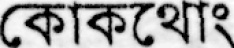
কোকথোং
